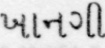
ખાનગી
